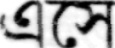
এসে
